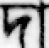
দা
